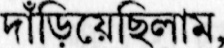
দাঁড়িয়েছিলাম,
